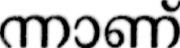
ന്നാണ്
